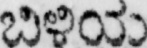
ಬಿಳಿಯ
